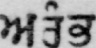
ਅਰੰਭ
